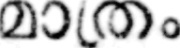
മാത്രം
